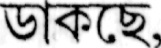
ডাকছে,
